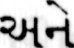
અને
